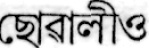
ছোৱালীও
